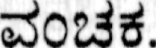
ವಂಚಕ.
